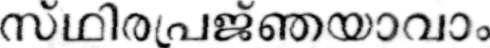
സ്ഥിരപ്രജ്ഞയാവാം
